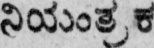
ನಿಯಂತ್ರಕ
